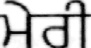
ਮੇਰੀ
